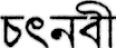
চৎনবী
